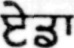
ਏਡਾ
